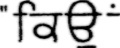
''ਕਿਉਂ
